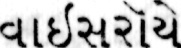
વાઇસરૉયે
